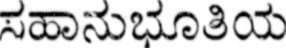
ಸಹಾನುಭೂತಿಯ
